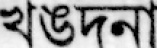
খঙদনা
